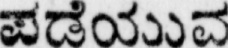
ಪಡೆಯುವ
